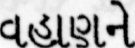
વહાણને
